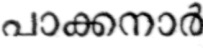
പാക്കനാര്‍
